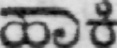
ಹಾಕಿ
